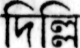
দিল্লি
